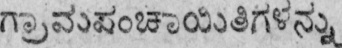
ಗ್ರಾಮಪಂಚಾಯಿತಿಗಳನ್ನು
